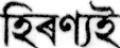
হিৰণ্যই
